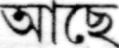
আছে
